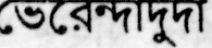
ভেরেন্দাদুদা
